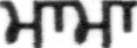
ਮਾਮਾ
